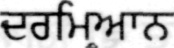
ਦਰਮਿਆਨ
